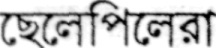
ছেলেপিলেরা
